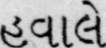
હવાલે
